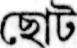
ছোট
